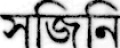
সজিনি
